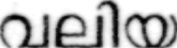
വലിയ
